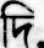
দি.
